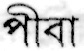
পীবা
